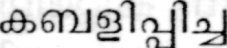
കബളിപ്പിച്ച
